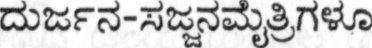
ದುರ್ಜನ-ಸಜ್ಜನಮೈತ್ರಿಗಳೂ
